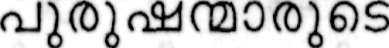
പുരുഷന്മാരുടെ
